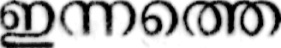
ഇന്നത്തെ
